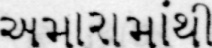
અમારામાંથી
